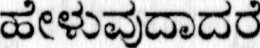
ಹೇಳುವುದಾದರೆ
